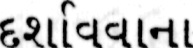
દર્શાવવાના
